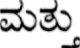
ಮತ್ತು
